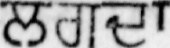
ਲਗਦਾ
